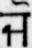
ਜੋ
